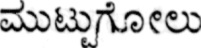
ಮುಟ್ಟುಗೋಲು
